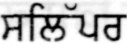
ਸਲਿੱਪਰ
